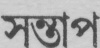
সন্তাপ
